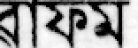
ৱাফম
